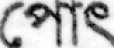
পোৎ
